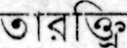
তারক্ত্রি
